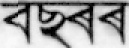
বছৰৰ
